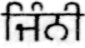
ਜਿੰਨੀ
